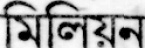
মিলিয়ন
